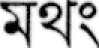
মথং
